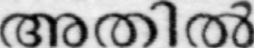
അതില്‍
